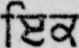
ਇਕ
